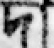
দা
